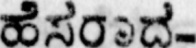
ಹೆಸರಾದ-
